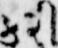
કરી
